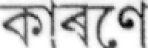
কাৰণে
